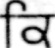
ਕਿ
